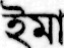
ইমা
